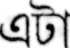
এটা
